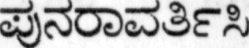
ಪುನರಾವರ್ತಿಸಿ
